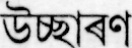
উচ্ছাৰণ
